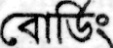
বোর্ডিং
